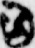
છે
